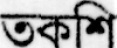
তকশি
